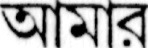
আমার
